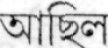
আছিল
